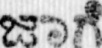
ಜಾಗೆ
